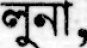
লুনা,
